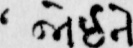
'જોઈને
